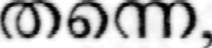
തന്നെ,
